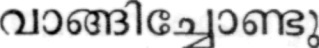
വാങ്ങിച്ചോണ്ടു
